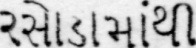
રસોડામાંથી
